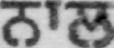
ਨਾਲ
